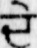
ਦੇ
